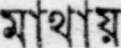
মাথায়
